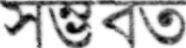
সম্ভবত
